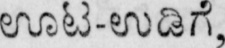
ಊಟ-ಉಡಿಗೆ,
